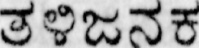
ತಳಿಜನಕ
